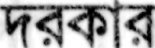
দরকার
